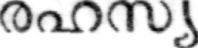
രഹസ്യ
